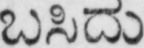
ಬಸಿದು
